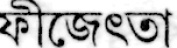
ফীজেৎতা
